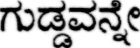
ಗುಡ್ಡವನ್ನೇ
